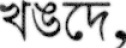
খঙদ্রে,
